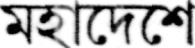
মহাদেশে
